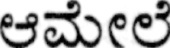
ಆಮೇಲೆ
